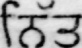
ਨਿੱਤ
